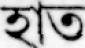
হাত
